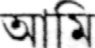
আমি
